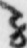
કે
